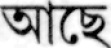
আছে
